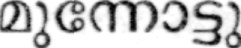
മുന്നോട്ടു
